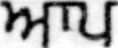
ਆਪ
